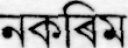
নকৰিম
